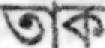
তাক
